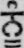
ਨੂੰ
